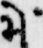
મેં
